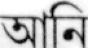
আনি
